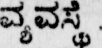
ವ್ಯವಸ್ಥೆ
